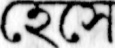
হেসে
